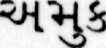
અમુક
